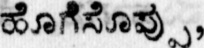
ಹೊಗೆಸೊಪ್ಪು,
